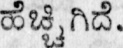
ಹೆಚ್ಚಿಗಿದೆ.
